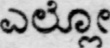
ಎಲ್ಲೋ
